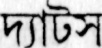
দ্যাটস
